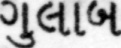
ગુલાબ
